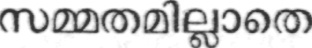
സമ്മതമില്ലാതെ
